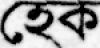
হেক
